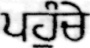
ਪਹੁੰਚੇ
